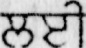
ਲਈ
